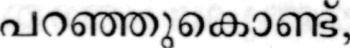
പറഞ്ഞുകൊണ്ട്,
